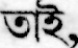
তাই,
